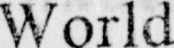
World
